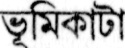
ভূমিকাটা
